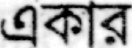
একার
